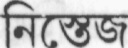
নিস্তেজ
